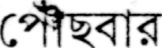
পৌঁছবার
